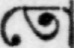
তো
